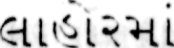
લાહોરમાં
